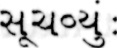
સૂયવ્યું:
